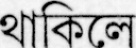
থাকিলে
